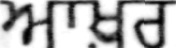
ਆਖ਼ਰ
